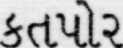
કતપોર
